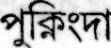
পুক্নিংদা
